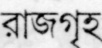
রাজগৃহ
